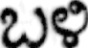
ಬಳಿ
